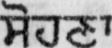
ਸੋਹਣਾ
